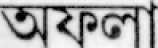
অফলা
